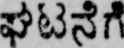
ಘಟನೆಗೆ
